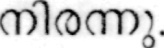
നിരന്നു.
